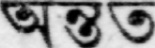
অন্তত
